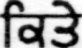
ਕਿਤੇ
